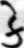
કે
